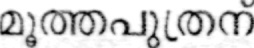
മൂത്തപുത്രന്
